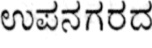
ಉಪನಗರದ
